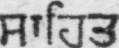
ਸਾਹਿਤ
